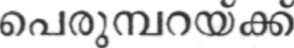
പെരുമ്പറയ്ക്ക്
